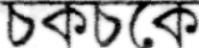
চকচকে
